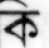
কি
